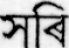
সৰি
